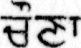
ਚੌਣਾ
